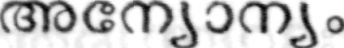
അന്യോന്യം
